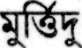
মুর্ত্তিদু
